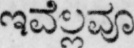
ಇವೆಲ್ಲವೂ
